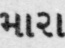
મારા
